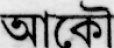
আকৌ
